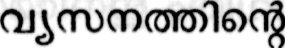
വ്യസനത്തിന്റെ
